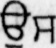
ਉਸ
